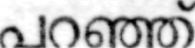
പറഞ്ഞ്
